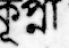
কুপ্না
